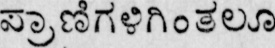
ಪ್ರಾಣಿಗಳಿಗಿಂತಲೂ
